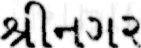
શ્રીનગર
